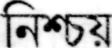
নিশ্চয়
